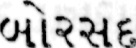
બોરસદ
